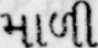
માળી
